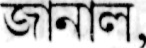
জানাল,
